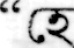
“হে
